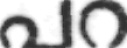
പറ
